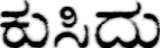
ಕುಸಿದು
